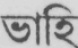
ভাহি
